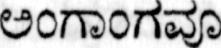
ಅಂಗಾಂಗವೂ
